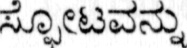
ಸ್ಫೋಟವನ್ನು
